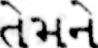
તેમને
